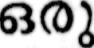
ഒരു
